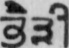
ਭੈੜੀ
